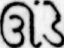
ઊંડે
